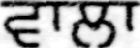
ਵਾਲਾ
